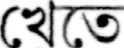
খেতে
